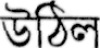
উঠিল
